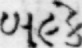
બલ્કે
